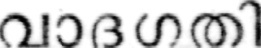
വാദഗതി
